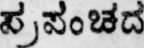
ಪ್ರಪಂಚದ
